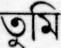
তুমি
